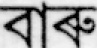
বাৰু
